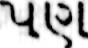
પણ
